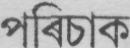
পৰিচাক
